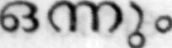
ഒന്നും
